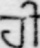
ਹੀ
